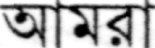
আমরা
